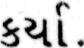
કર્યા.
